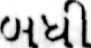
બધી
